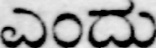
ಎಂದು
